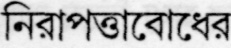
নিরাপত্তাবোধের
